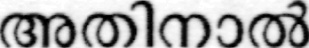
അതിനാല്‍
